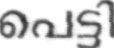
പെട്ടി
